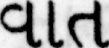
વાત
